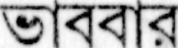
ভাববার
